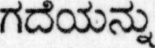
ಗದೆಯನ್ನು
